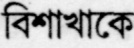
বিশাখাকে
